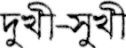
দুখী-সুখী
